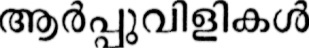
ആര്‍പ്പുവിളികള്‍
